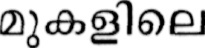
മുകളിലെ
